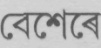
বেশেৰে
